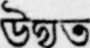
উদ্যত
